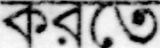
করতে
